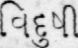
વિદુષી
